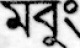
মবুং
